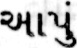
આપું
